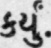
કર્યું.
